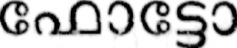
ഫോട്ടോ
